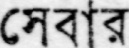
সেবার
